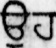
ਉਹ
